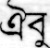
ঐবু
